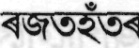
ৰজতহঁতৰ
